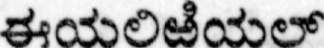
ಈಯಲಿಱಯಲ್
